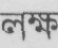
লক্ষ
